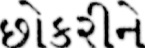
છોકરીને
